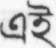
এই
